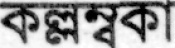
কল্লম্বকা
